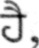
ਹੈ,
